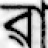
ৱা
